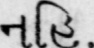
નહિ.
